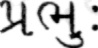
પ્રભુઃ
